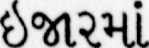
ઇજારમાં
